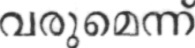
വരുമെന്ന്
